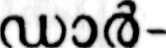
ഡാര്‍-
